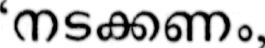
‘നടക്കണം,
